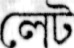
লেট
